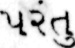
પરંતુ
